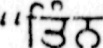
''ਤਿੰਨ
